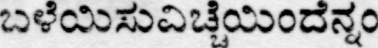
ಬಳೆಯಿಸುವಿಚ್ಚೆಯಿಂದೆನ್ನಂ
